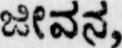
ಜೀವನ,
